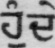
ਹੁੰਦੇ
